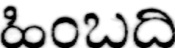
ಹಿಂಬದಿ
